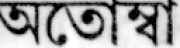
অতোম্বা
